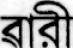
ৱারী
